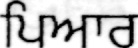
ਪਿਆਰ
